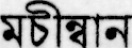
মচীন্বান
